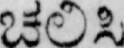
ಚಲಿಸಿ
